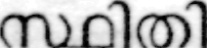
സ്ഥിതി
